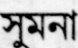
সুমনা
